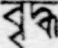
বৃদ্ধ
